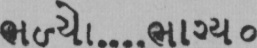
ભળ્યો....ભાગ્ય.
